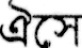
ঐসে
